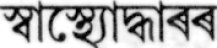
স্বাস্হ্যোদ্ধাৰৰ
